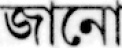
জানো
